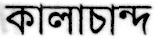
কালাচান্দ
